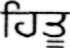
ਹਿਤੂ
